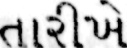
તારીખે
